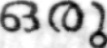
ഒരു
